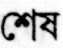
শেষ
